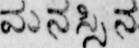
ಮನಸ್ಸಿನ
